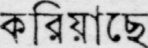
করিয়াছে
